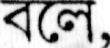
বলে,
